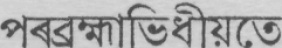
পৰব্ৰহ্মাভিধীয়তে
